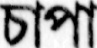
চাপা
